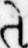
તે
